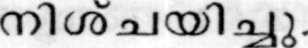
നിശ്ചയിച്ചു.
